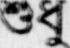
শুধু
